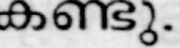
കണ്ടു.
